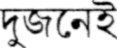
দুজনেই
